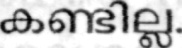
കണ്ടില്ല.
